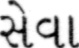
સેવા
